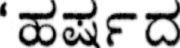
‘ಹರ್ಷದ
